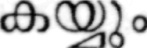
കയ്യും
